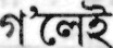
গ'লেই
